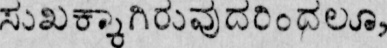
ಸುಖಕ್ಕಾಗಿರುವುದರಿಂದಲೂ,
